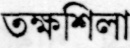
তক্ষশিলা
